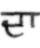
ਦਾ
